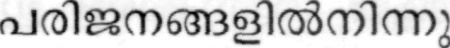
പരിജനങ്ങളില്‍നിന്നു
